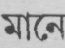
মানে
